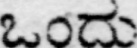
ಒಂದು
